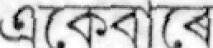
একেবাৰে
